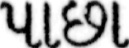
પાછા
